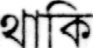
থাকি
